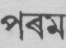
পৰম
